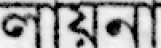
লায়না
